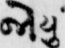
જોયું
